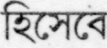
হিসেবে
